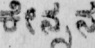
ಕೇನ್ಸನ
